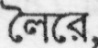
লৈরে,
